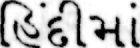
હિંદીમાં
